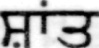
ਸ਼ਾਂਤ
